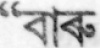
"বাৰু
